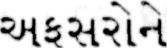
અફસરોને
